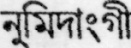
নুমিদাংগী
